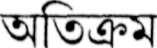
অতিক্রম
